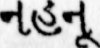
નહનૂ
